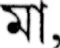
মা,
